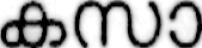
കസാ
